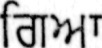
ਗਿਆ
